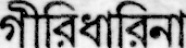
গীরিধারিনা
